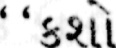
"કશો
